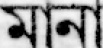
মানা
